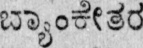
ಬ್ಯಾಂಕೇತರ
